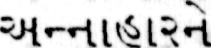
અન્નાહારને
